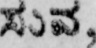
ಸುವ,
